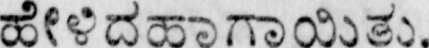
ಹೇಳಿದಹಾಗಾಯಿತು.
